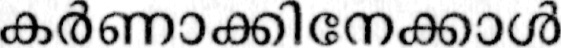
കര്‍ണാക്കിനേക്കാള്‍
